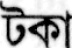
টকা
